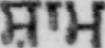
ਸ਼ਾਮ
